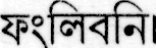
ফংলিবনি।
